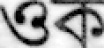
ওক
